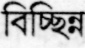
বিচ্ছিন্ন
